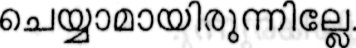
ചെയ്യാമായിരുന്നില്ലേ.
